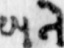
બને
